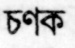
চণক
